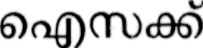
ഐസക്ക്
